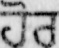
ਹੋਰ
